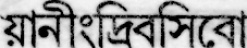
য়ানীংদ্রিবসিবো
